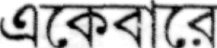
একেবারে
